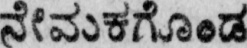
ನೇಮಕಗೊಂಡ
